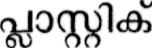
പ്ലാസ്റ്റിക്
